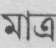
মাত্ৰ
